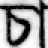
চা
